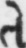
તે
